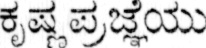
ಕೃಷ್ಣಪ್ರಜ್ಞೆಯು
